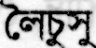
লৈচুসু
